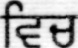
ਵਿਚ
